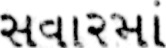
સવારમાં
